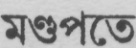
মণ্ডপতে
